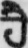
ਹੈ
